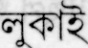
লুকাই
